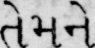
તેમને
